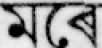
মৰে
